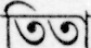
তিতা
